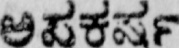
ಅಪಕರ್ಷ
